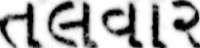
તલવાર
